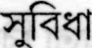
সুবিধা
